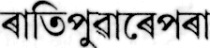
ৰাতিপুৱাৰেপৰা
